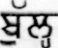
ਬੁੱਲ੍ਹ
